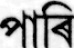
পাৰি
